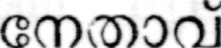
നേതാവ്
